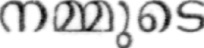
നമ്മുടെ
